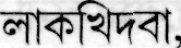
লাকখিদবা,
